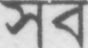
সব
